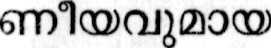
ണീയവുമായ
